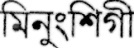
মিনুংশিগী
